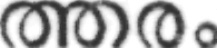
ത്തരം
